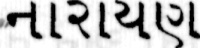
નારાયણ
